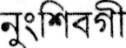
নুংশিবগী
